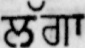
ਲੱਗਾ
